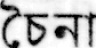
চৈনা
